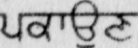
ਪਕਾਉਣ
